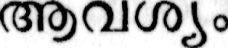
ആവശ്യം
